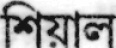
শিয়াল
